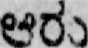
ಆರು
